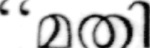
"മതി
